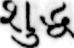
શુદ્ધ
